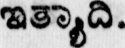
ಇತ್ಯಾದಿ.
